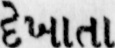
દેખાતા
